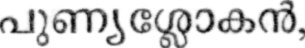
പുണ്യശ്ലോകന്‍,
